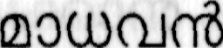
മാധവന്‍
